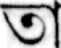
তা
